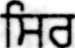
ਸਿਰ
